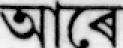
আৰে
